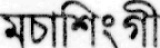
মচাশিংগী
